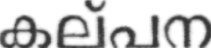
കല്പന
